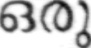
ഒരു
